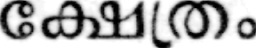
ക്ഷേത്രം
